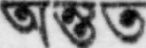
অন্তত
